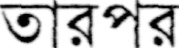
তারপর
